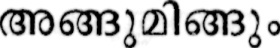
അങ്ങുമിങ്ങും
